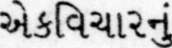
એકવિચારનું
